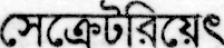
সেক্রেটরিয়েৎ
